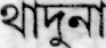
থাদুনা
